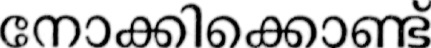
നോക്കിക്കൊണ്ട്
